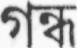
গন্ধ
